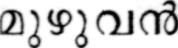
മുഴുവന്‍
